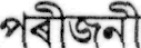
পৰীজনী
